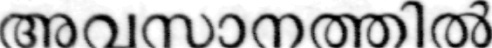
അവസാനത്തില്‍
